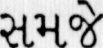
સમજે
